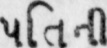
પતિની
